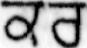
ਕਰ
